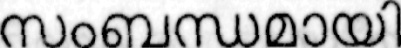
സംബന്ധമായി
